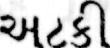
અટકી
